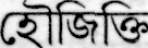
হৌজিক্তি
